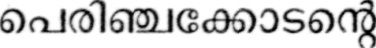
പെരിഞ്ചക്കോടന്റെ
